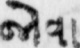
જોવા
